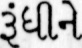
રૂંધીને
